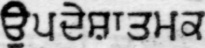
ਉਪਦੇਸ਼ਾਤਮਕ
